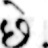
છે.
